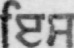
ਇਸ
